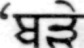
'ਬੜੇ
